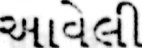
આવેલી
